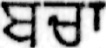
ਬਚਾ
